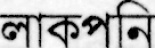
লাকপনি
